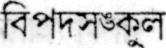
বিপদসঙ্কুল
